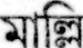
মাল্লি
